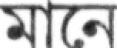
মানে
